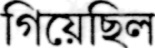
গিয়েছিল
